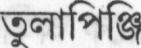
তুলাপিঞ্জি
